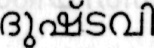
ദുഷ്ടവി
